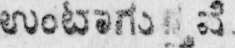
ಉಂಟಾಗುತ್ತವೆ.
